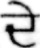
ਦੇ
